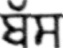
ਬੱਸ
